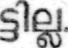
ട്ടില്ല.
